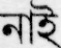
নাই
